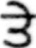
ਤੇ
